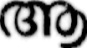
ആ
